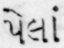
પેલાં
